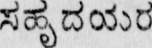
ಸಹೃದಯರ
